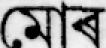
মোৰ
